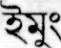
ইমুং
